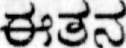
ಈತನ
